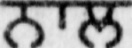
ਨਾਲ
